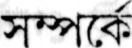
সম্পর্কে
